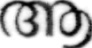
ആ
